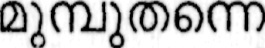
മുമ്പുതന്നെ
